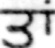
ਤਾਂ
